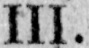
III.
